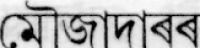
মৌজাদাৰৰ
